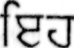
ਇਹ
